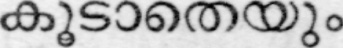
കൂടാതെയും
